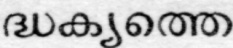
ദ്ധക്യത്തെ
